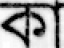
কা
